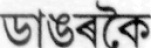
ডাঙৰকৈ
